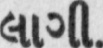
લાગી.
